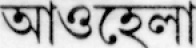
আওহেলা
